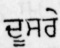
ਦੂਸਰੇ
